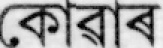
কোৱাৰ
